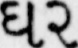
ઘર
